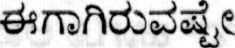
ಈಗಾಗಿರುವಷ್ಟೇ
